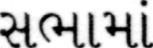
સભામાં
